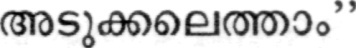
അടുക്കലെത്താം”
